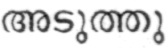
അടുത്തു
